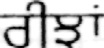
ਰੀਝਾਂ
